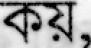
কয়,
